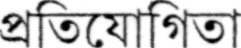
প্রতিযোগিতা
